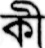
কী
